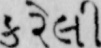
કરેલી
